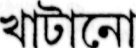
খাটানো
